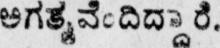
ಅಗತ್ಯವೆ೦ದಿದ್ದಾರೆ.
